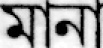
মানা
